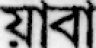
য়াবা
